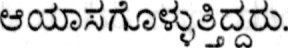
ಆಯಾಸಗೊಳ್ಳುತ್ತಿದ್ದರು.
